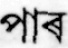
পাৰ
